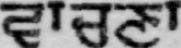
ਵਾਚਣਾ
